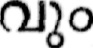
വും
